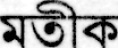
মতীক
